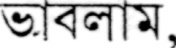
ভাবলাম,
